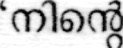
‘നിന്റെ
